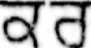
ਕਰ
